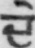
ਦੇ
